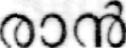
രാന്‍
